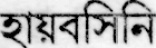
হায়বসিনি
